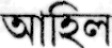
আহিল
